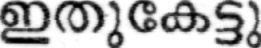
ഇതുകേട്ടു
